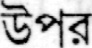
উপর
